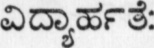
ವಿದ್ಯಾರ್ಹತೆ:
